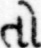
તો
